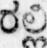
ರಲ್ಲಿ
